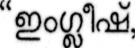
'ഇംഗ്ലീഷ്,
